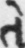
તે
